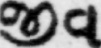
જીવ
